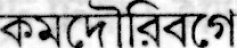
কমদৌরিবগে
